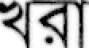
খরা
